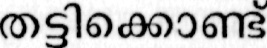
തട്ടിക്കൊണ്ട്
